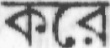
করে
